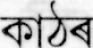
কাঠৰ
